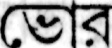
ভোর
